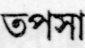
তপসা
